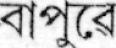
বাপুৱে
